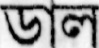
ডাল
